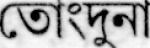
তোংদুনা
